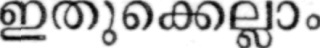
ഇതുക്കെല്ലാം
